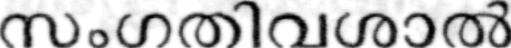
സംഗതിവശാല്‍
